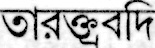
তারক্ত্রবদি
